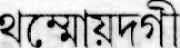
থম্মোয়দগী
